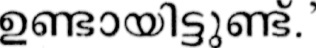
ഉണ്ടായിട്ടുണ്ട്.’
